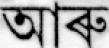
আৰু
